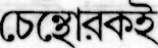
চেন্থোরকই
